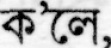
ক'লে,
